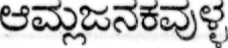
ಆಮ್ಲಜನಕವುಳ್ಳ
